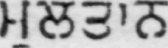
ਮੁਲਤਾਨ
